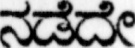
ನಡೆದೇ
